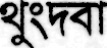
থুংদবা
